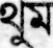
থুম
